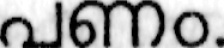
പണം.
